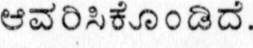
ಆವರಿಸಿಕೊಂಡಿದೆ.
